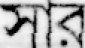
সার
